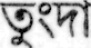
তুংদা
